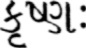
કૃષ્ણઃ
